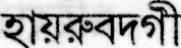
হায়রুবদগী
